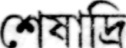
শেষাদ্রি
